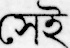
সেই
